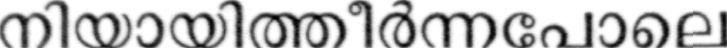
നിയായിത്തീര്‍ന്നപോലെ
